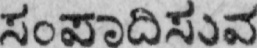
ಸಂಪಾದಿಸುವ
